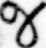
જ
